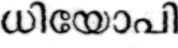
ധിയോപി
